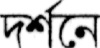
দর্শনে
